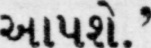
આપશે.'
